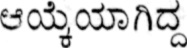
ಆಯ್ಕೆಯಾಗಿದ್ದ
